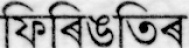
ফিৰিঙতিৰ
